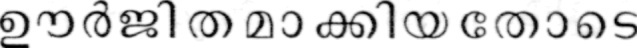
ഊര്‍ജിതമാക്കിയതോടെ
